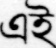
এই
